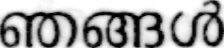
ഞങ്ങള്‍
